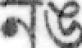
নঙ
